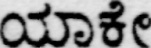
ಯಾಕೇ
